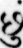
છું
